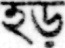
হড়
